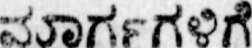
ಮಾರ್ಗಗಳಿಗೆ
